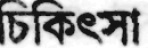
চিকিৎসা
